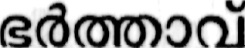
ഭര്‍ത്താവ്
